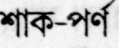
শাক-পর্ণ
